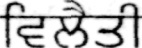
ਵਿਲੈਤੀ
